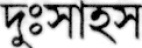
দুঃসাহস
